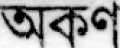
অকণ
